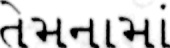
તેમનામાં
